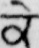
ਕੇ
